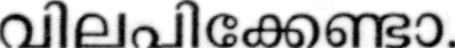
വിലപിക്കേണ്ടാ.
